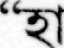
“হা
